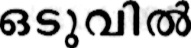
ഒടുവില്‍
